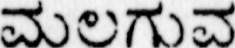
ಮಲಗುವ
